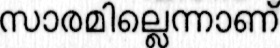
സാരമില്ലെന്നാണ്
